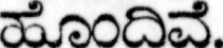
ಹೊಂದಿವೆ.
